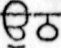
ਉਠ
